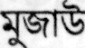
মুজাউ
